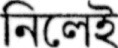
নিলেই
